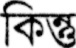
কিন্তু
